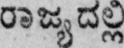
ರಾಜ್ಯದಲ್ಲಿ
